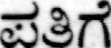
ಪತಿಗೆ
